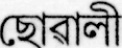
ছোৱালী
